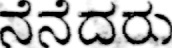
ನೆನೆದರು
